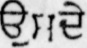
ਉਸਦੇ
